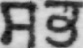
ਸਭ
